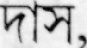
দাস,
